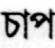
চাপ
